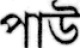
পাউ
